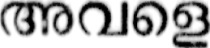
അവളെ
